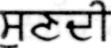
ਸੁਣਦੀ
